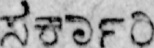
ಸರ್ಕಾರಿ
